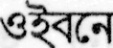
ওইবনে
